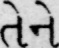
તેને
